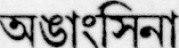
অঙাংসিনা
